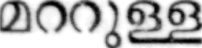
മററുള്ള
